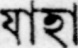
যাহা
